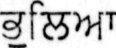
ਭੁਲਿਆ
